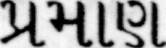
પ્રમાણ
